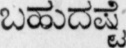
ಬಹುದಷ್ಟೆ
